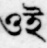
ওই
